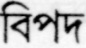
বিপদ
